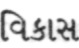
વિકાસ
